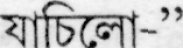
যাচিলো-"
